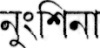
নুংশিনা
